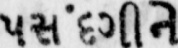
પસંદગીને
